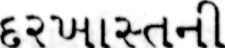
દરખાસ્તની
